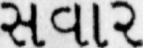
સવાર
